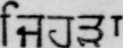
ਜਿਹੜਾ
